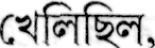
খেলিছিল,
